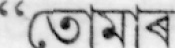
"তোমাৰ
